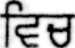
ਵਿਚ
